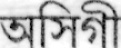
অসিগী
